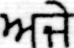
ਅਜੇ
